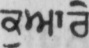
ਕੁਆਰੇ
